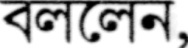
বললেন,
